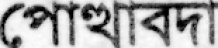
পোত্থাবদা
